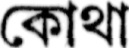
কোথা
